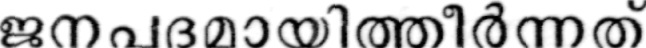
ജനപദമായിത്തീര്‍ന്നത്
